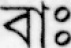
বাঃ
